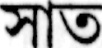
সাত
